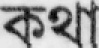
কথা
